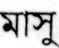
মাসূ
